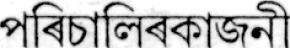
পৰিচালিৰকাজনী
